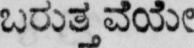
ಬರುತ್ತವೆಯೇ
